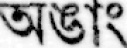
অঙাং
